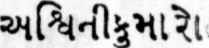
અશ્વિનીકુમારો
